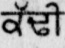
ਕੱਢੀ
